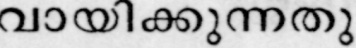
വായിക്കുന്നതു
